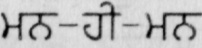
ਮਨ-ਹੀ-ਮਨ
